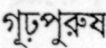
গূঢ়পুরুষ
